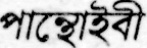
পান্থোইবী
